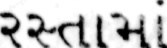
રસ્તામાં
